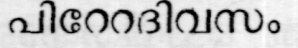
പിറേറദിവസം
